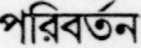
পরিবর্তন
